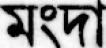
মংদা
